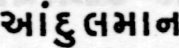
આંદુલમાન
